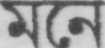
মনে
